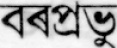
বৰপ্রভু
